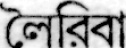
লৈরিবা
